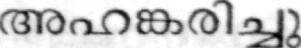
അഹങ്കരിച്ചു
